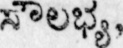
ಸೌಲಭ್ಯ,
